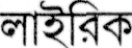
লাইরিক
